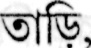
তাড়ি,
